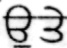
ਉਤੇ
